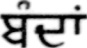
ਬੰਦਾਂ
